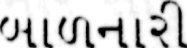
બાળનારી
